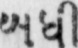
બધી
